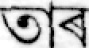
তাৰ
